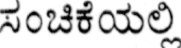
ಸಂಚಿಕೆಯಲ್ಲಿ
